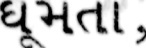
ઘૂમતા,
